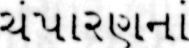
ચંપારણનાં
